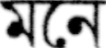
মনে
